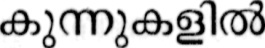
കുന്നുകളില്‍
